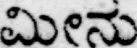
ಮೀನು
